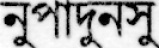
নুপাদুনসু
